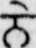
ਨੇ
